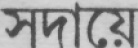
সদায়ে
